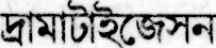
দ্রামাটাইজেসন
